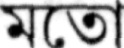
মতো
